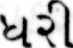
ધરી
